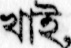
খাই,
